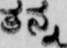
ತನ್ನ
